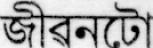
জীৱনটো
